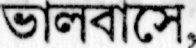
ভালবাসে,
